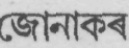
জোনাকৰ
